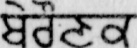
ਬੇਰੌਣਕ
